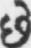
છે
